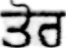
ਤੋਰ
